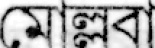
মোল্লবা
